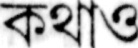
কথাও
